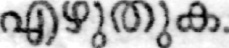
എഴുതുക.
